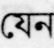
যেন
